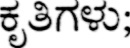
ಕೃತಿಗಳು;
